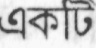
একটি
